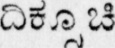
ದಿಕ್ಸೂಚಿ
